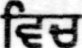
ਵਿਚ
